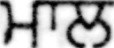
ਮਾਲ
